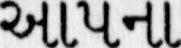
આપના
